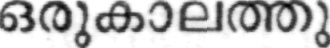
ഒരുകാലത്തു
